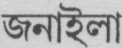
জনাইলা
